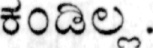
ಕಂಡಿಲ್ಲ.
